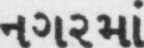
નગરમાં
